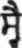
ਸ੍ਵੈ
